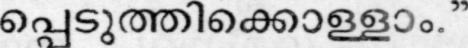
പ്പെടുത്തിക്കൊള്ളാം."
